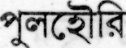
পুলহৌরি
